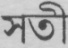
সতী
